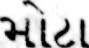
મોટા
